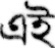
এই
